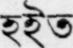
হইত
